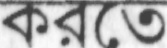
করতে
